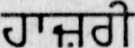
ਹਾਜ਼ਰੀ
